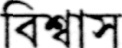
বিশ্বাস
